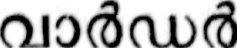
വാര്‍ഡര്‍
